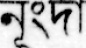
নূংদা
